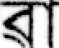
ৱা
